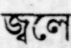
জ্বলে
